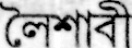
লৈশাবী
